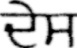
ਦੇਸ
